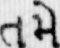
તમે
